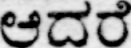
ಆದರೆ
